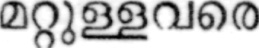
മറ്റുള്ളവരെ
